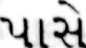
પાસે
